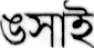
ঙসাই
